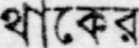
থাকের
